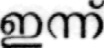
ഇന്ന്
